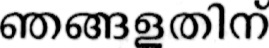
ഞങ്ങളതിന്
